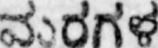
ಮರಗಳ
